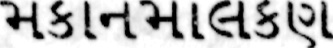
મકાનમાલકણ
